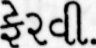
ફેરવી.
